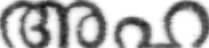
അഹ
